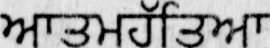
ਆਤਮਹੱਤਿਆ
